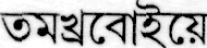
তমখ্রবোইয়ে
